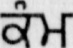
ਕੰਮ
